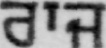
ਰਾਜ
